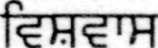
ਵਿਸ਼ਵਾਸ
